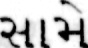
સામે
